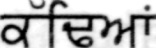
ਕੱਢਿਆਂ
